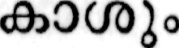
കാശും
